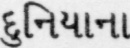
દુનિયાના
